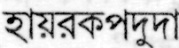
হায়রকপদুদা
